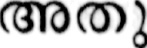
അതു
